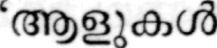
'ആളുകള്‍
